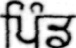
ਪਿੰਡ
